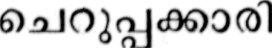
ചെറുപ്പക്കാരി
